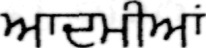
ਆਦਮੀਆਂ
